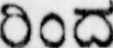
ರಿಂದ
